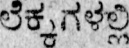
ಲೆಕ್ಕಗಳಲ್ಲಿ
